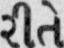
રીતે
